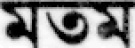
মতম
